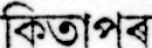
কিতাপৰ
